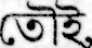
তৌই,
